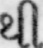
થી
